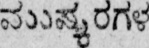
ಮುಷ್ಕರಗಳ
